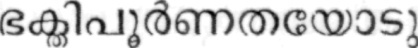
ഭക്തിപൂര്‍ണതയോടു
